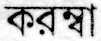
করম্বা
